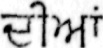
ਦੀਆਂ
